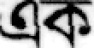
এক
